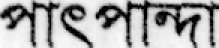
পাৎপান্দা
